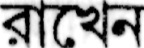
রাখেন
